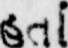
હતાં
